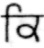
ਕਿ
